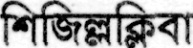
শিজিল্লক্লিবা
